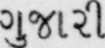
ગુજારી
